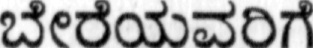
ಬೇರೆಯವರಿಗೆ
